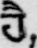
ਹੈ,
